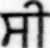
ਸੀ
